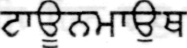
ਟਾਊਨਮਾਉਥ
